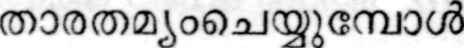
താരതമ്യംചെയ്യുമ്പോള്‍
